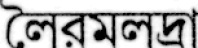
লৈরমলদ্রা
